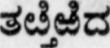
ತೞ್ತಱದ
